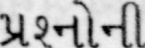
પ્રશ્નોની
